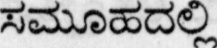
ಸಮೂಹದಲ್ಲಿ
